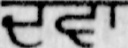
ਦਵਾ
